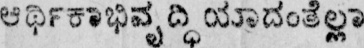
ಅರ್ಥಿಕಾಭಿವೃದ್ಧಿಯಾದಂತೆಲ್ಲಾ
